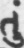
તું
